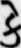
કે
